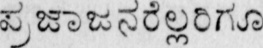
ಪ್ರಜಾಜನರೆಲ್ಲರಿಗೂ
